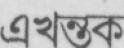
এখন্তক
